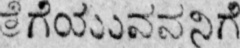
ತೆಗೆಯುವವನಿಗೆ
